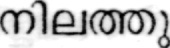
നിലത്തു
